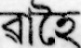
ৱাহৈ
